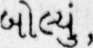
બોલ્યું,
